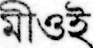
মীওই
